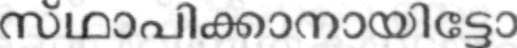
സ്ഥാപിക്കാനായിട്ടോ
